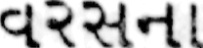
વરસના
